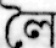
লৈ
